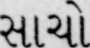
સાચો
